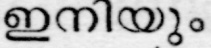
ഇനിയും
